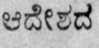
ಆದೇಶದ
